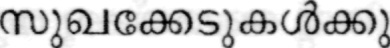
സുഖക്കേടുകള്‍ക്കു
